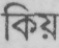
কিয়
